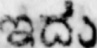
ಇದು
